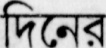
দিনের
